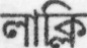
লাক্লি
